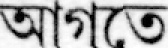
আগতে
